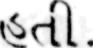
હતી.
